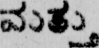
ಮತ್ತು
